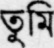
তুমি
